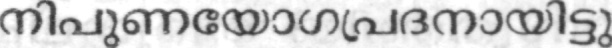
നിപുണയോഗപ്രദനായിട്ടു
